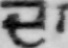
ਦਾ
